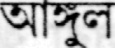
আঙ্গুল
